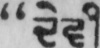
''ਦੇਵੀ
